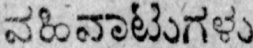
ವಹಿವಾಟುಗಳು
